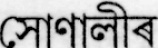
সোণালীৰ
